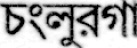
চংলুরগা
